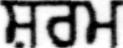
ਸ਼ਰਮ
